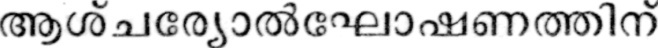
ആശ്ചര്യോല്‍ഘോഷണത്തിന്
